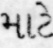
માટે
